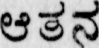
ಆತನ
